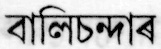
বালিচন্দাৰ
